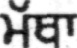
ਮੱਥਾ
